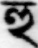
হু
